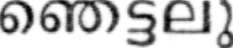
ഞെട്ടലു
